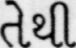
તેથી
